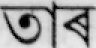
তাৰ
